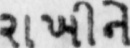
રાખીને
